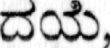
ದಯೆ,
